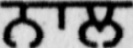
ਨਾਲ
